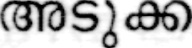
അടുക്ക
